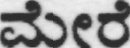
ಮೇರೆ
